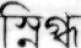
স্নিগ্ধ
